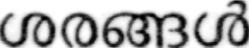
ശരങ്ങള്‍
